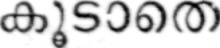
കൂടാതെ
